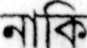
নাকি
